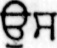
ਉਸ
